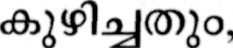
കുഴിച്ചതും,
